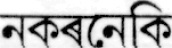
নকৰনেকি
